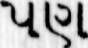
પણ
